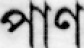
পাণ
